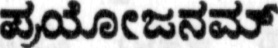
ಪ್ರಯೋಜನಮ್
